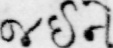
જઈને
